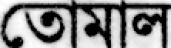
তোমাল
